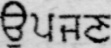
ਉਪਜਣ
